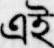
এই
